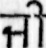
ਜੀ
